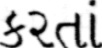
કરતાં
